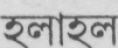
হলাহল
